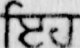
ਇਹ
